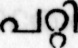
പറ്റി
